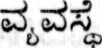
ವ್ಯವಸ್ಥೆ
